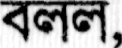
বলল,
